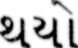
થયો
